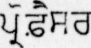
ਪ੍ਰੋਫ਼ੈਸਰ
